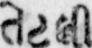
તેટલી
